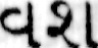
વશ
